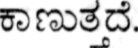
ಕಾಣುತ್ತದೆ.
